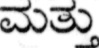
ಮತ್ತು
